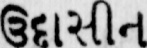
ઉદાસીન
